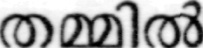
തമ്മില്‍
